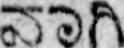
ವಾಗಿ
